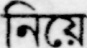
নিয়ে
